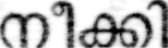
നീക്കി
